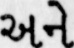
અને
